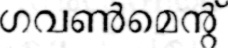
ഗവണ്‍മെന്റ്
